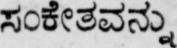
ಸಂಕೇತವನ್ನು
